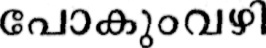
പോകുംവഴി
